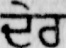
ਦੇਰ
